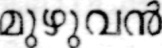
മുഴുവന്‍
